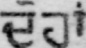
ਦੋਹਾਂ
